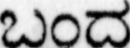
ಬಂದ
